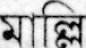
মাল্লি
